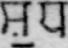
ਸ਼ੁਧ
